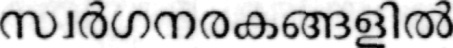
സ്വര്‍ഗനരകങ്ങളില്‍
